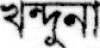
খন্দুনা
